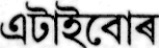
এটাইবোৰ
